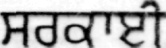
ਸਰਕਾਈ
